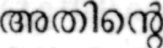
അതിന്റെ
